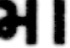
મા
